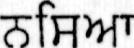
ਨਸਿਆ
